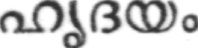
ഹൃദയം
